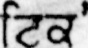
ਟਿਕ'
